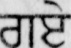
ਗਏ
